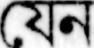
যেন
